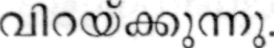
വിറയ്ക്കുന്നു.
